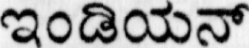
ಇಂಡಿಯನ್
